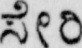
ಸೇರಿ
